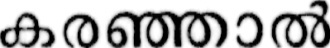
കരഞ്ഞാല്‍
